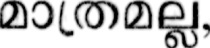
മാത്രമല്ല,
